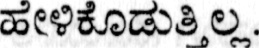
ಹೇಳಿಕೊಡುತ್ತಿಲ್ಲ.
